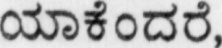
ಯಾಕೆಂದರೆ,
